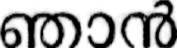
ഞാന്‍
